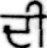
ਦੀ
